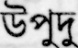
উপুদু
